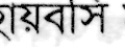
হায়বসি
